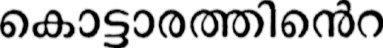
കൊട്ടാരത്തിന്റെ
